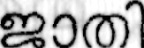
ജാതി
